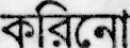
করিনো
